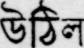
উঠিল
